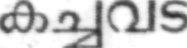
കച്ചവട
